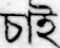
চাই
